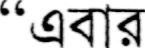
“এবার
